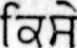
ਕਿਸੇ
